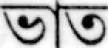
ভাত
